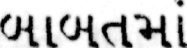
બાબતમાં
